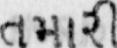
તમારી
